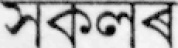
সকলৰ
